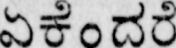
ಏಕೆಂದರೆ
